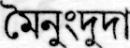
মৈনুংদুদা
